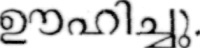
ഊഹിച്ചു.
